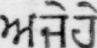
ਅਜੇਹੇ
